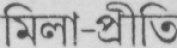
মিলা-প্ৰীতি
